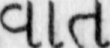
વાત
